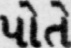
પોતે
